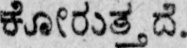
ಕೋರುತ್ತದೆ.
